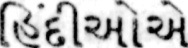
હિંદીઓએ
